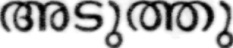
അടുത്തു
